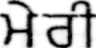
ਮੇਰੀ
